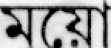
ময়ো
